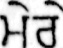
ਮੇਰੇ
